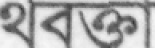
থবক্তা
